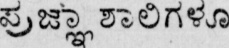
ಪ್ರಜ್ಞಾಶಾಲಿಗಳೂ
